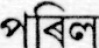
পৰিল
